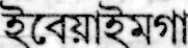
ইবেয়াইমগা
